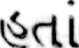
હતાં
